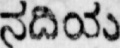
ನದಿಯ
